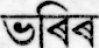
ভৰিৰ
